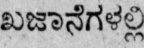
ಖಜಾನೆಗಳಲ್ಲಿ
